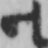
ન
